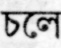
চলে
